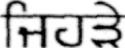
ਜਿਹੜੇ
